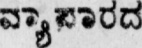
ವ್ಯಾಪಾರದ
